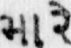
મારે
